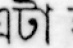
এটা
